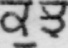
ਕੁਝ
